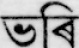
ভৰি
